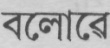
বলোৱে
